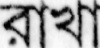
রাখা
